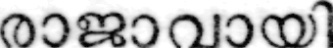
രാജാവായി
